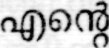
എന്റെ
